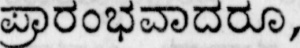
ಪ್ರಾರಂಭವಾದರೂ,
